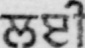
ਲਈ
